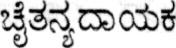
ಚೈತನ್ಯದಾಯಕ
